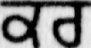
ਕਰ
